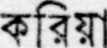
করিয়া
